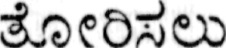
ತೋರಿಸಲು
